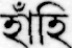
হাঁহি
